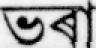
ভৰা
